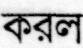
করল
